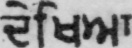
ਦੇਖਿਆ
